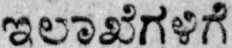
ಇಲಾಖೆಗಳಿಗೆ
